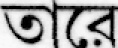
তারে
